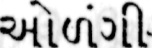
ઓળંગી
